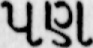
પણ
